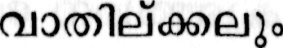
വാതില്ക്കലും
